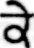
ਕੇ
